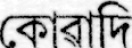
কোৱাদি
